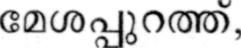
മേശപ്പുറത്ത്,
